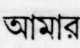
আমার
